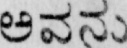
ಅವನು
